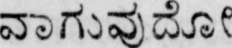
ವಾಗುವುದೋ
